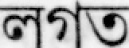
লগত
